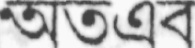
অতএব
